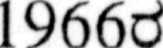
1966ರ
